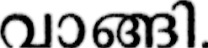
വാങ്ങി.
